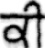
ਕੀ
